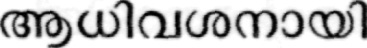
ആധിവശനായി
